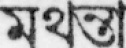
মথন্তা
